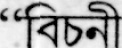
"বিচনী
